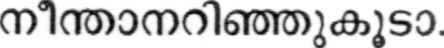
നീന്താനറിഞ്ഞുകൂടാ.
